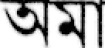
অমা
